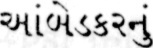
આંબેડકરનું
